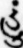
હું
